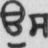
ਉਸ
